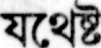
যথেষ্ট
